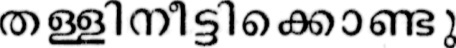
തള്ളിനീട്ടിക്കൊണ്ടു
